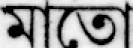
মাতো
